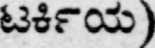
ಟಕಿ೯ಯ)
